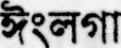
ঈংলগা
